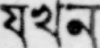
যখন
